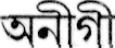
অনীগী
